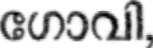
ഗോവി,
